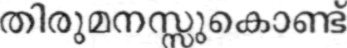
തിരുമനസ്സുകൊണ്ട്
